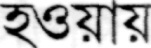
হওয়ায়
